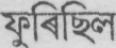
ফুৰিছিল
